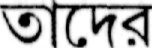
তাদের
